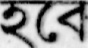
হবে
